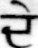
ਦੇ
